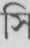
সি
